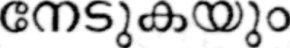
നേടുകയും
